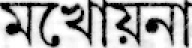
মখোয়না
